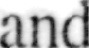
and
